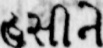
હસીને
